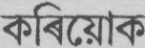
কৰিয়োক
